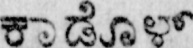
ಕಾಡೊಳ್
